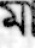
মা
